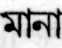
মানা
